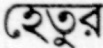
হেতুর
